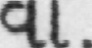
વા.
